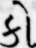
કો
